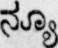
ನ್ಯೂ
